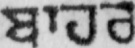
ਬਾਹਰ
